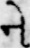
ને
